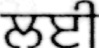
ਲਈ
